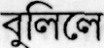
বুলিলে
